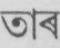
তাৰ
